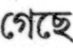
গেছে
